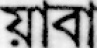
য়াবা
